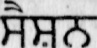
ਸੈਸ਼ਨ
